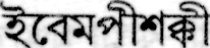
ইবেমপীশক্কী
